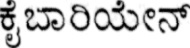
ಕೈಬಾರಿಯೇನ್
